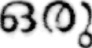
ഒരു
